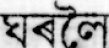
ঘৰলৈ
